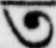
ত
